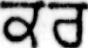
ਕਰ
